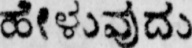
ಹೇಳುವುದು
